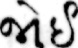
જોઈ
